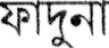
ফাদুনা
